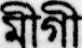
মীগী
